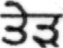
ਤੇੜ
